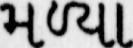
મળ્યા
